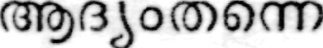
ആദ്യംതന്നെ
